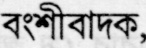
বংশীবাদক,
